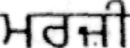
ਮਰਜ਼ੀ
